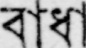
বাধা
